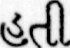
હતી
